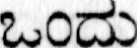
ಒಂದು
